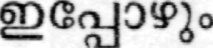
ഇപ്പോഴും
